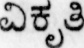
ವಿಕೃತಿ
